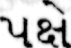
પક્ષે
